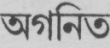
অগনিত
